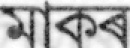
মাকৰ
